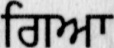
ਗਿਆ
